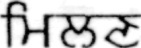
ਮਿਲਣ
